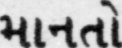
માનતો
